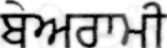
ਬੇਅਰਾਮੀ
